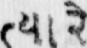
ત્યારે
